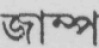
জাম্প
